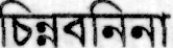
চিন্নবনিনা
